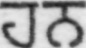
ਹਨ
